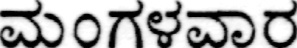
ಮಂಗಳವಾರ
